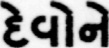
દેવોને
